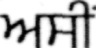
ਅਸੀਂ
